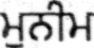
ਮੁਨੀਮ
